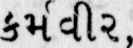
કર્મવીર,
